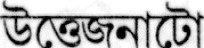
উত্তেজনাটো
